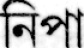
নিপা
